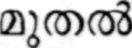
മുതല്‍
